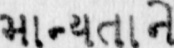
માન્યતાને
